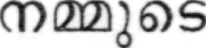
നമ്മുടെ
